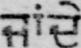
ਜਾਂਦੇ
